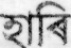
হাৰি
